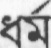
ধর্ম
